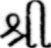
શ્રી
